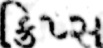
ક્રિપ્સ
